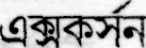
এক্সকর্সন
